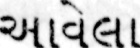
આવેલા
